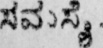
ಸಮಸ್ಯೆ.
